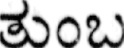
ತುಂಬ
